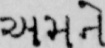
અમને
